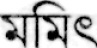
মমিৎ
